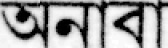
অনাবা
